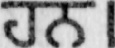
ਹਨ।
